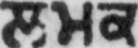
ਲਮਕ
